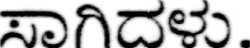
ಸಾಗಿದಳು.
